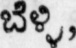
ಬೆಳ್ಳಿ,
